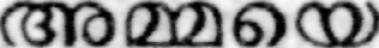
അമ്മയെ
